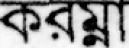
করম্না
